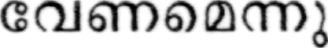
വേണമെന്നു
